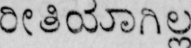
ರೀತಿಯಾಗಿಲ್ಲ
